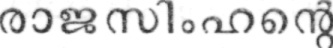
രാജസിംഹന്റെ
